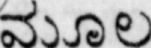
ಮೂಲ
